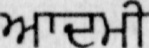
ਆਦਮੀ
